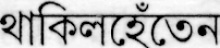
থাকিলহেঁতেন
